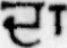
ਦਾ
